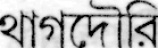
থাগদৌরি
